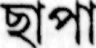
ছাপা
